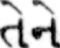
તેને
